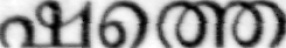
ഷത്തെ
